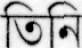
তিনি
